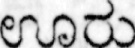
ಊರು
